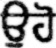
ਉਹੋ
